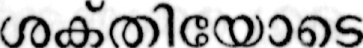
ശക്തിയോടെ
